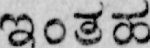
ಇಂತಹ
